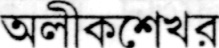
অলীকশেখর
